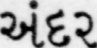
અંદર
